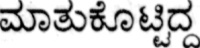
ಮಾತುಕೊಟ್ಟಿದ್ದ
